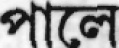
পালে
